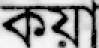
কয়া
